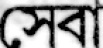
সেবা
